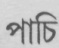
পাচি
